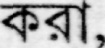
করা,
